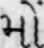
મોં
